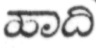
ಹಾದಿ
